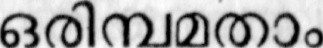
ഒരിമ്പമതാം
